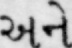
અને
